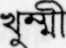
খুম্মী
